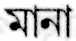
মানা
